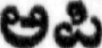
ಅಪಿ
